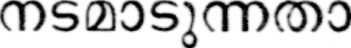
നടമാടുന്നതാ
